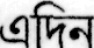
এদিন
